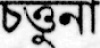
চত্তুনা
